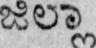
ಜಿಲ್ಲಾ
